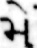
મેં
